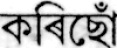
কৰিছোঁ
